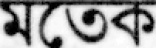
মতেক
